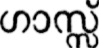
ഗാസ്സ്
